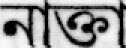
নাক্তা
